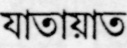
যাতায়াত
